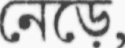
নেড়ে,
